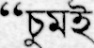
“চুমই
